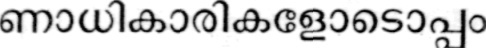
ണാധികാരികളോടൊപ്പം
